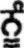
ਨੂੰ
